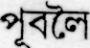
পূবলৈ
